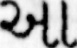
આ
